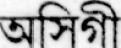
অসিগী
